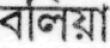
বলিয়া
